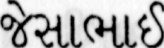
જેસાભાઈ
